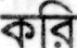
করি
